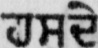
ਹਸਦੇ
